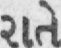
રાતે
